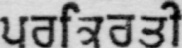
ਪਰਕਿਰਤੀ
